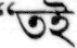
"তই
